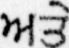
ਅਤੇ
